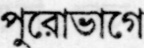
পুরোভাগে
